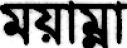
ময়াম্না
